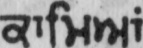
ਕਾਮਿਆਂ
